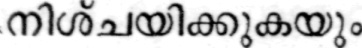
നിശ്ചയിക്കുകയും
